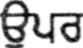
ਉਪਰ
